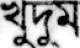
খুদুম
